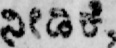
ನೀಡಿಕೆ,
